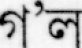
গ'ল
